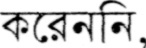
করেননি,
